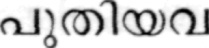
പുതിയവ
